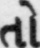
તો
